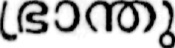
ഭ്രാന്തു
